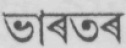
ভাৰতৰ
